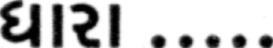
ધારા......
